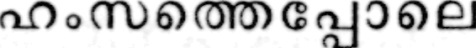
ഹംസത്തെപ്പോലെ
